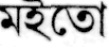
মইতো
